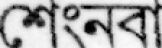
শেংনবা
